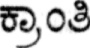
ಕ್ರಾಂತಿ
